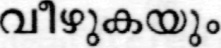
വീഴുകയും
